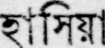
হাসিয়া
